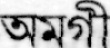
অমগী
